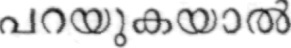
പറയുകയാല്‍
